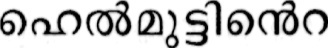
ഹെല്‍മുട്ടിന്റെ
